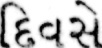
દિવસે
